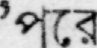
’পরে
